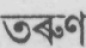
তৰুণ
